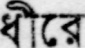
ধীরে
